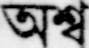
অশ্ব
